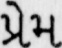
પ્રેમ
